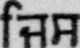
ਜਿਸ
